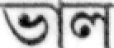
ভাল
